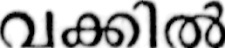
വക്കില്‍
